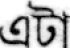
এটা
